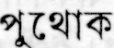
পুথোক
